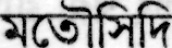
মতৌসিদি
